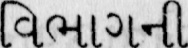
વિભાગની
